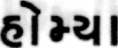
હોમ્યા
